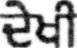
ਦੇਖੀ
